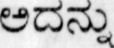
ಅದನ್ನು
